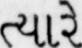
ત્યારે
